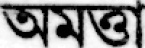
অমত্তা
